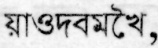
য়াওদবমখৈ,
